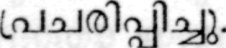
പ്രചരിപ്പിച്ചു.
